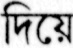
দিয়ে
